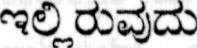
ಇಲ್ಲಿರುವುದು
